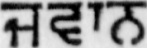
ਜਵਾਨ
